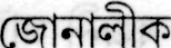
জোনালীক
